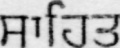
ਸਾਹਿਤ
